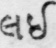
લઈ
